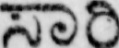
ಸಾರಿ
